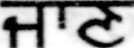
ਜਾਣ
